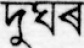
দুঘৰ
